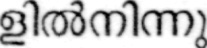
ളില്‍നിന്നു
